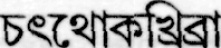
চৎথোকখিব্রা
